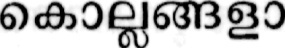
കൊല്ലങ്ങളാ
